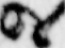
જ
